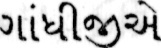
ગાંધીજીએ
